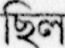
ছিল
